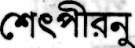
শেৎপীরনু
